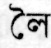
লৈ
